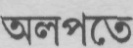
অলপতে
